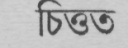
চিত্তত
